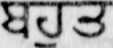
ਬਹੁਤ
